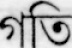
গতি
